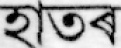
হাতৰ
